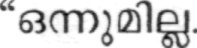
“ഒന്നുമില്ല.
